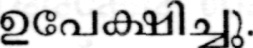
ഉപേക്ഷിച്ചു.
